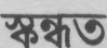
স্কন্ধত
